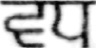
ਵਧ
